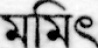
মমিৎ
